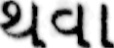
થવા
